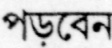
পড়বেন
